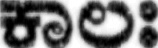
ಕಾಲಃ
